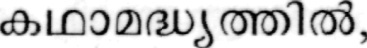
കഥാമദ്ധ്യത്തില്‍,
